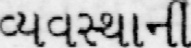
વ્યવસ્થાની
